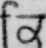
ਕਿ
